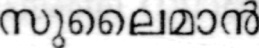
സുലൈമാന്‍
